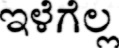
ಇಳೆಗೆಲ್ಲ
